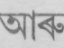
আৰু
